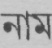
নাম
